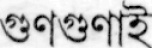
গুণগুণাই
